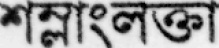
শম্লাংলক্তা
